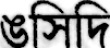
ঙসিদি
